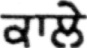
ਕਾਲੇ
